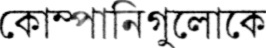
কোম্পানিগুলোকে
